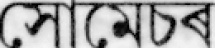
সোমেচৰ
